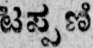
ಟಿಪ್ಪಣಿ
